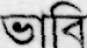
ভাবি
